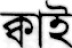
ক্বাই
